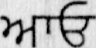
ਆਓ
